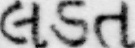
લડત
